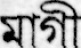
মাগী
